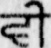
ਵੀ
